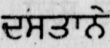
ਦਸਤਾਨੇ
